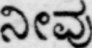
ನೀವು
